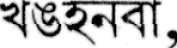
খঙহনবা,
